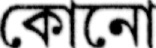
কোনো
